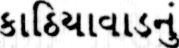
કાઠિયાવાડનું
